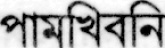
পামখিবনি
